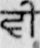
ਵੀ
